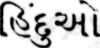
હિંદુઓ
